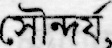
সৌন্দর্য,
